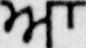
ਆ
